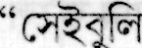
"সেইবুলি
